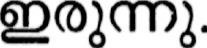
ഇരുന്നു.
